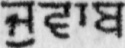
ਜੁਵਾਬ
